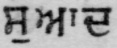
ਸੁਆਦ
